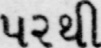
પરથી
